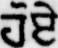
ਹੋਏ
